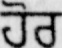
ਹੋਰ
